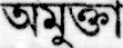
অমুক্তা
